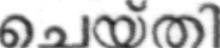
ചെയ്തി
